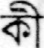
কী
